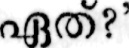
ഏത്?'
